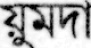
য়ুমদা
